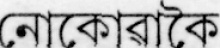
নোকোৱাকৈ
